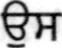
ਉਸ
